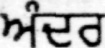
ਅੰਦਰ
